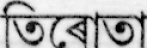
তিৰোতা
